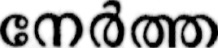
നേര്‍ത്ത
